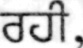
ਰਹੀ,
